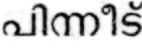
പിന്നീട്
